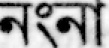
নংনা
